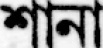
শানা
